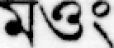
মওং
